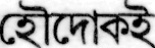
হৌদোকই
